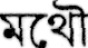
মথৌ
